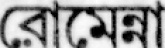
রোমেন্না
